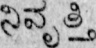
ನಿವೃತ್ತಿ
